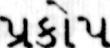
પ્રકોપ
